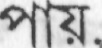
পায়,
